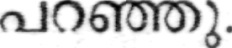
പറഞ്ഞു.
